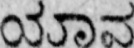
ಯಾವ
